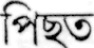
পিছত
